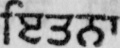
ਇਤਨਾ
